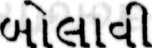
બોલાવી
